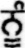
ਨੂੰ
